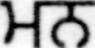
ਮਨ
